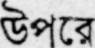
উপরে
